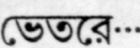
ভেতরে...
